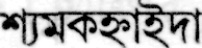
শ্যামকহ্ণাইদা
